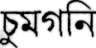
চুমগনি
